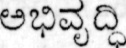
ಅಭಿವೃದ್ಧಿ
